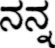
ನನ್ನ
